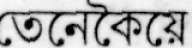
তেনেকৈয়ে
